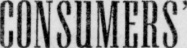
CONSUMERS
